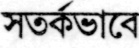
সতর্কভাবে
